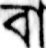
বা
